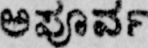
ಅಪೂರ್ವ
